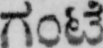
ಗಂಟೆ
